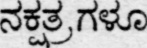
ನಕ್ಷತ್ರಗಳೂ
